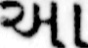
આ
